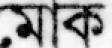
মোক
